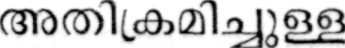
അതിക്രമിച്ചുള്ള
